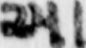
આ
